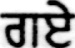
ਗਏ
